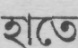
হাতে
